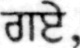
ਗਏ,
